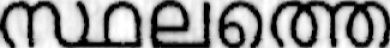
സ്ഥലത്തെ
